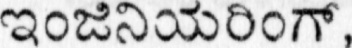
ಇಂಜಿನಿಯರಿಂಗ್,
